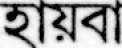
হায়বা
